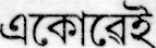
একোৱেই
